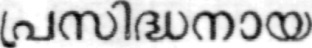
പ്രസിദ്ധനായ
